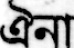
ঐনা
